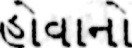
હોવાનો
